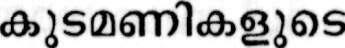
കുടമണികളുടെ
